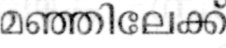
മഞ്ഞിലേക്ക്
